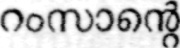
റംസാന്റെ
